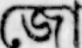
জো
